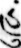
હું
